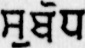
ਸੁਬੋਧ
